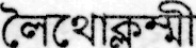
লৈথোক্লম্মী
